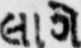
લાગે
